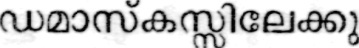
ഡമാസ്കസ്സിലേക്കു
